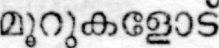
മൂറുകളോട്
